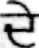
ਦੇ
